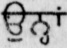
ਉਨ੍ਹਾਂ
